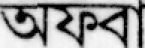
অফবা
